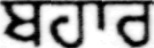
ਬਹਾਰ
